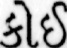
કોઈ
